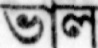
ভাল
